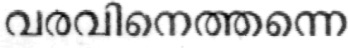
വരവിനെത്തന്നെ
